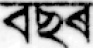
বছৰ
